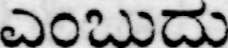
ಎಂಬುದು
